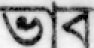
ভাব
